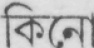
কিনো
